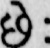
છેઃ
